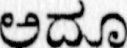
ಅದೂ
